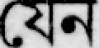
যেন
